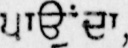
ਪਾਉਂਦਾ,
